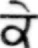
ਕੇ
